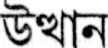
উত্থান
